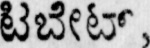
ಟಿಬೇಟ್,
